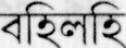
বহিলহি
